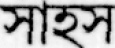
সাহস
